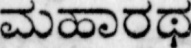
ಮಹಾರಥ
